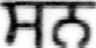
ਸਨ
